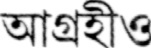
আগ্রহীও
